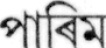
পাৰিম
